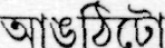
আঙঠিটো
